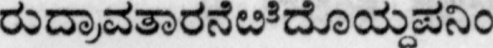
ರುದ್ರಾವತಾರನೆೞೆದೊಯ್ದಪನಿಂ
